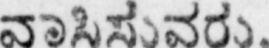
ವಾಸಿಸುವರು.
